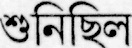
শুনিছিল
